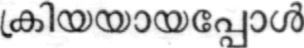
ക്രിയയായപ്പോള്‍
